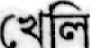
খেলি
